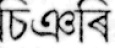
চিঞৰি
